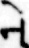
ને
